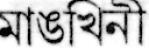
মাঙখিনী
